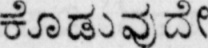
ಕೊಡುವುದೇ
